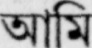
আমি
